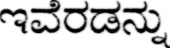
ಇವೆರಡನ್ನು
